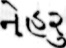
નેહરુ
